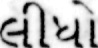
લીધો
